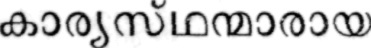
കാര്യസ്ഥന്മാരായ
